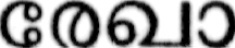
രേഖാ
